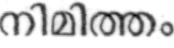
നിമിത്തം
